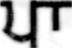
ਪਾ
